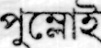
পুম্লোই
